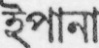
ইপানা
